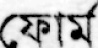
ফোর্ম
